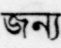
জন্য
